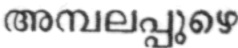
അമ്പലപ്പുഴെ
